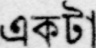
একটা
